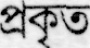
প্রকৃত
